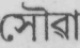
সৌৱা
